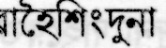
ৱাহৈশিংদুনা
